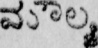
ಮೌಲ್ಯ
